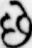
છે
